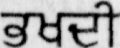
ਭਖਦੀ
